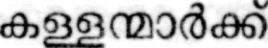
കള്ളന്മാര്‍ക്ക്
